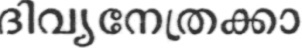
ദിവ്യനേത്രക്കാ
